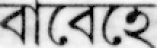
বাবেহে
